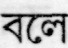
বলে
